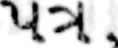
પત્ર,
